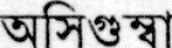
অসিগুম্বা
